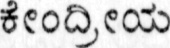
ಕೇಂದ್ರೀಯ
